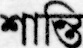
শান্তি
